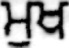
ਮੁਖ
